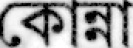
কোন্না
